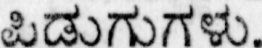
ಪಿಡುಗುಗಳು.
